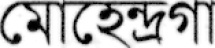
মোহেন্দ্রগা
